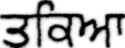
ਤਕਿਆ
